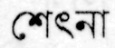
শেৎনা
